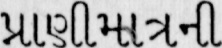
પ્રાણીમાત્રની
